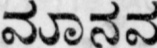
ಮಾನವ
